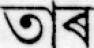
তাৰ
